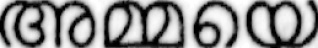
അമ്മയെ
